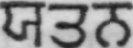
ਯਤਨ
